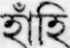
হাঁহি
